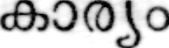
കാര്യം
